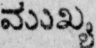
ಮುಖ್ಯ
